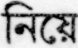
নিয়ে
